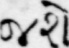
જશે
